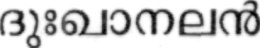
ദുഃഖാനലന്‍
